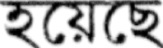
হয়েছে
